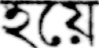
হয়ে
